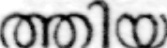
ത്തിയ
